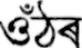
ওঁঠৰ
